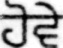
ਹੋਵੇ
